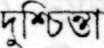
দুশ্চিন্তা
